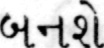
બનશે
